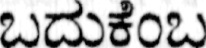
ಬದುಕೆಂಬ
